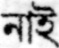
নাই
